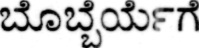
ಬೊಬ್ಬೆರ್ಯೆಗೆ
